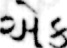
એક
